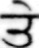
ਤੇ
